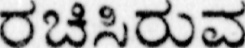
ರಚಿಸಿರುವ
